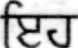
ਇਹ
